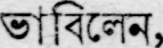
ভাবিলেন,
